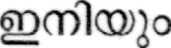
ഇനിയും
